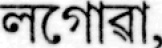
লগোৱা,
